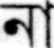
না
